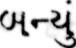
બન્યું
